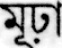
মূঢ়া
